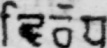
ਵਿਰੋਧ
